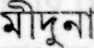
মীদুনা
